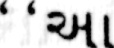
"આ
